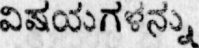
ವಿಷಯಗಳನ್ನು
